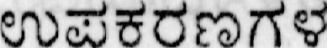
ಉಪಕರಣಗಳ
